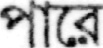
পারে
